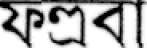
ফত্ত্রবা
